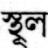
স্থূল
